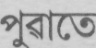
পুৱাতে
